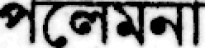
পলেমনা
